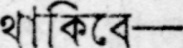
থাকিবে—
